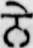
ਨੇ
